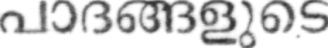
പാദങ്ങളുടെ
